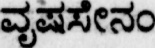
ವೃಷಸೇನಂ
